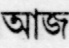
আজ
